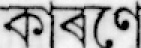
কাৰণে
